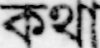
কথা
